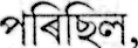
পৰিছিল,
